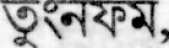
তুংনফম,
